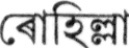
ৰোহিল্লা
